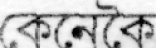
কেনেকৈ
